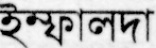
ইম্ফালদা
